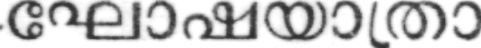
ഘോഷയാത്രാ
